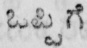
ಒಪ್ಪಿಗೆ
